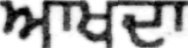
ਆਖਦਾ
